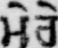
ਮੇਰੇ
